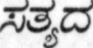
ಸತ್ಯದ
